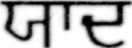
ਯਾਦ
